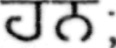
ਹਨ;
